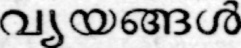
വ്യയങ്ങള്‍
